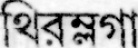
থিরম্লগা
